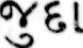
જુદા
